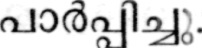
പാര്‍പ്പിച്ചു.
